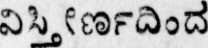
ವಿಸ್ತೀರ್ಣದಿಂದ
